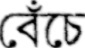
বেঁচে
